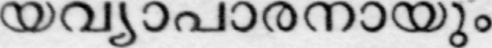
യവ്യാപാരനായും
